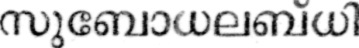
സുബോധലബ്ധി
